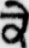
ਕੇ
